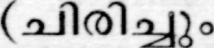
(ചിരിച്ചും
